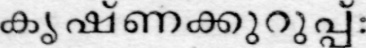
കൃഷ്ണക്കുറുപ്പ്:
